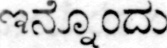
ಇನ್ನೊಂದು
